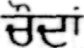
ਚੌਦਾਂ
